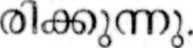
രിക്കുന്നു.
